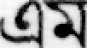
এম
